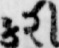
કરી
